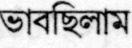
ভাবছিলাম
